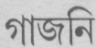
গাজনি
